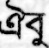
ঐবু
